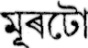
মূৰটো
